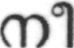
നീ
